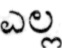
ಎಲ್ಲ
